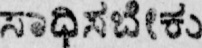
ಸಾಧಿಸಬೇಕು
